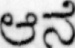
ಆನೆ
